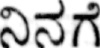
ನಿನಗೆ
